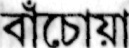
বাঁচোয়া
